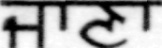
ਜਾਣਾ
